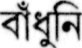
বাঁধুনি
